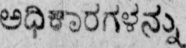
ಅಧಿಕಾರಗಳನ್ನು
